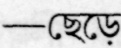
–ছেড়ে
